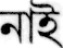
নাই
